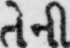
તેની
